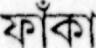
ফাঁকা
